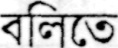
বলিতে
